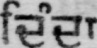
ਦਿੰਦਾ
